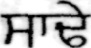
ਸਾਢੇ
